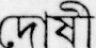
দোষী
